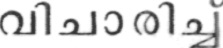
വിചാരിച്ച്
